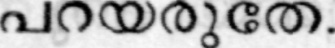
പറയരുതേ.
